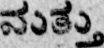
ಮತ್ತು
